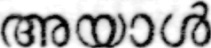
അയാള്‍
